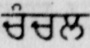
ਚੰਚਲ
